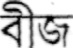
বীজ
